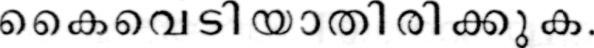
കൈവെടിയാതിരിക്കുക.
